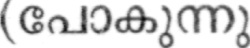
(പോകുന്നു.
